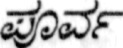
ಪೂರ್ವ
